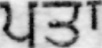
ਪਤਾ
